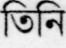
তিনি
